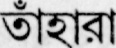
তাঁহারা
